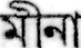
মীনা
